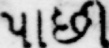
પાછી
